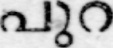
പുറ
